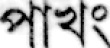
পাখং
